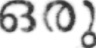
ഒരു
